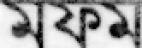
মফম
